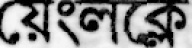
য়েংক্লে
